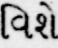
વિશે
